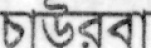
চাউরবা
